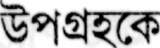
উপগ্রহকে
